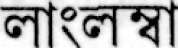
লাংলম্বা
